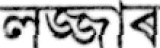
লজ্জাৰ
